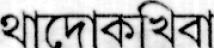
থাদোকখিবা
